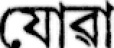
যোৱা
